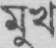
মুখ
